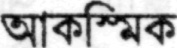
আকস্মিক
